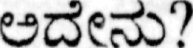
ಅದೇನು?
